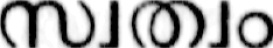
സ്വത്വം
